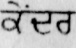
ਕੇਂਦਰ
